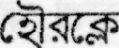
হৌরক্লে
